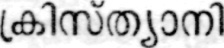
ക്രിസ്ത്യാനി
